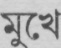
মুখে
